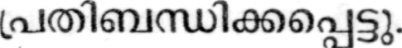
പ്രതിബന്ധിക്കപ്പെട്ടു.
